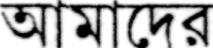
আমাদের
